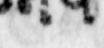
જાપ
